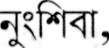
নুংশিবা,
